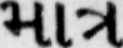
માત્ર
